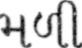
મળી
